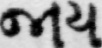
જાય
